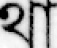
থা
